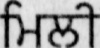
ਮਿਲੀ
